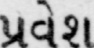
પ્રવેશ
